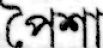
পৈশা
